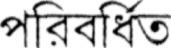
পরিবর্ধিত
